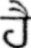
ਹੈ
